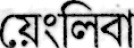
য়েংলিবা
